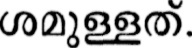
ശമുള്ളത്.
